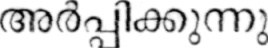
അര്‍പ്പിക്കുന്നു
